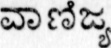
ವಾಣಿಜ್ಯ
